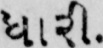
ધારી.
